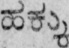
ಹಕ್ಕು
